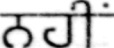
ਨਹੀਂ
